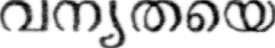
വന്യതയെ
